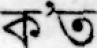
ক'ত
